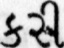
કરી
